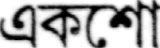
একশো
